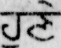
ਹੁਣੇ
